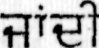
ਜਾਂਦੀ
